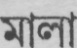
মালা
